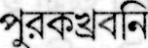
পুরকখ্রবনি
